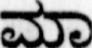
ಮಾ
